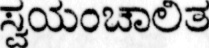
ಸ್ವಯಂಚಾಲಿತ
